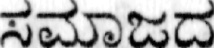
ಸಮಾಜದ
